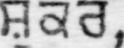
ਸ਼ੁਕਰ,
